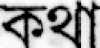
কথা
